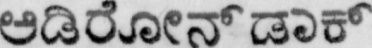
ಅಡಿರೋನ್‌ಡಾಕ್
